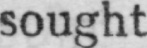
sought
